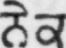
ਨੇਕ
